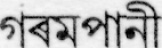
গৰমপানী
